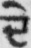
ਦੇ
